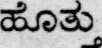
ಹೊತ್ತು
